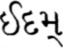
ઈદમ્
